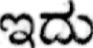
ಇದು
